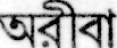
অরীবা
